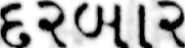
દરબાર
